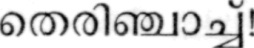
തെരിഞ്ചാച്ച്!
